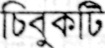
চিবুকটি
